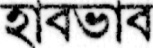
হাবভাব
